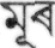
মূৰ
